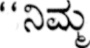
"ನಿಮ್ಮ
